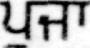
ਪੁਜਾ
